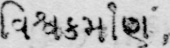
વિશ્વકર્માણં,
